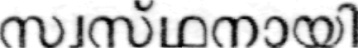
സ്വസ്ഥനായി
